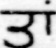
ਤਾਂ
